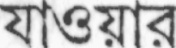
যাওয়ার
